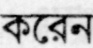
করেন
